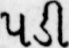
પડી
